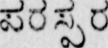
ಪರಸ್ಪರ
